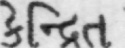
કેન્દ્રિત
